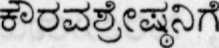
ಕೌರವಶ್ರೇಷ್ಠನಿಗೆ
